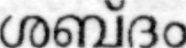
ശബ്ദം
